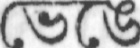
ভেঙে
